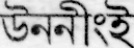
উননীংই
